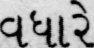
વધારે
